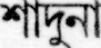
শাদুনা
